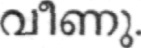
വീണു.
